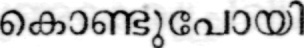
കൊണ്ടുപോയി
